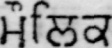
ਮੌਲਿਕ
